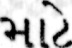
માટે
